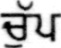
ਚੁੱਪ
